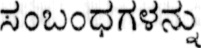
ಸಂಬಂಧಗಳನ್ನು
